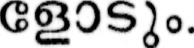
ളോടും.
